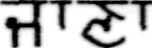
ਜਾਣਾ
